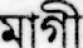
মাগী
